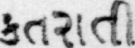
કતરાતી
